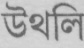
উথলি
